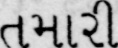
તમારી
